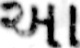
આ
